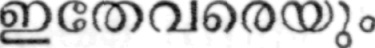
ഇതേവരെയും
